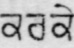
ਕਰਕੇ
